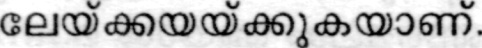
ലേയ്ക്കയയ്ക്കുകയാണ്.
